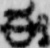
ಈ
